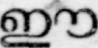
ഈ
